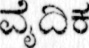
ವೈದಿಕ
